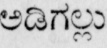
ಅಡಿಗಲ್ಲು
